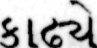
કાઢ્યે
